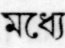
মধ্যে
